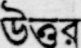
উত্তর
